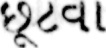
છૂટવા
